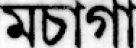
মচাগা
